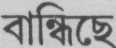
বান্ধিছে
